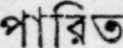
পারিত
